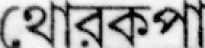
থোরকপা
